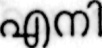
എനി
